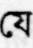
যে
